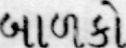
બાળકો
